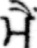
ਮੈਂ
